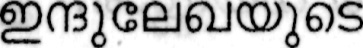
ഇന്ദുലേഖയുടെ
